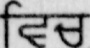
ਵਿਚ
